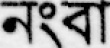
নংবা
